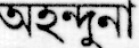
অহন্দুনা
